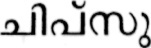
ചിപ്സു
